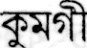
কুমগী
